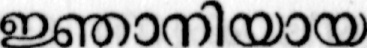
ജ്ഞാനിയായ
